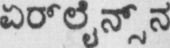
ಏರ್ ಲೈನ್ಸ್ ನ
